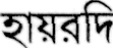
হায়রদি
